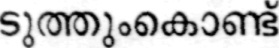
ടുത്തുംകൊണ്ട്
